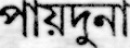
পায়দুনা
